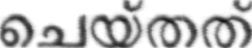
ചെയ്തത്
